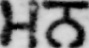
ਮਨ
